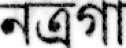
নত্রগা
